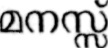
മനസ്സ്
